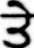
ਤੇ
